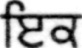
ਇਕ
